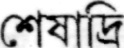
শেষাদ্রি
